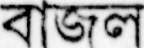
বাজল
